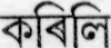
কৰিলি
